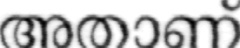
അതാണ്
